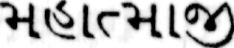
મહાત્માજી
